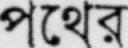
পথের
